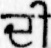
ਦੀ
